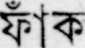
ফাঁক
